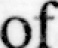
of
